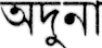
অদুনা
